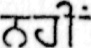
ਨਹੀਂ
